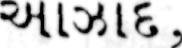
આઝાદ,
